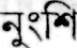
নুংশি
